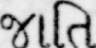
જાતિ
